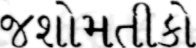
જશોમતીકો
